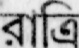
রাত্রি
